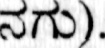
ನಗು).
